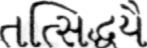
તત્સિદ્ધયૈ
